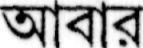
আবার
